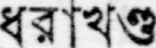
ধরাখণ্ড
